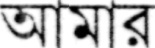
আমার
